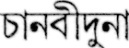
চানবীদুনা
